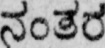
ನಂತರ
